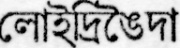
লোইদ্রিঙৈদা
